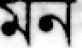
মন
